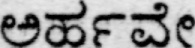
ಅರ್ಹವೇ
